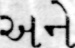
અને
